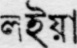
লইয়া
